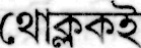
থোক্লকই
